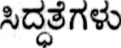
ಸಿದ್ಧತೆಗಳು
